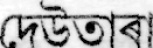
দেউতাৰা
